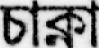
চাক্না
